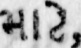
માટે,
